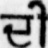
ਦੀ
